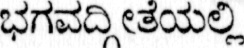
ಭಗವದ್ಗೀತೆಯಲ್ಲಿ
